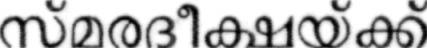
സ്മരദീക്ഷയ്ക്ക്
